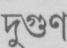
দুগুণ
